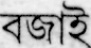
বজাই
